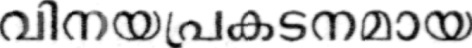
വിനയപ്രകടനമായ
